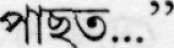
পাছত..."
